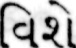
વિશે
